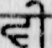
ਵੀ
